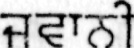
ਜਵਾਨੀ
